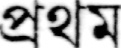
প্রথম
